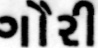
ગૌરી
